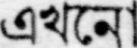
এখনো
